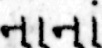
નાનાં
